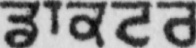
ਡਾਕਟਰ
